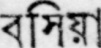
বসিয়া
